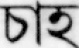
চাহ
